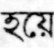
হয়ে
